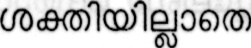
ശക്തിയില്ലാതെ
